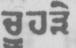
ਚੂਹੜੇ
